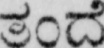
ತಂದೆ
